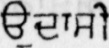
ਉਦਾਸੀ
